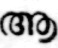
ആ
